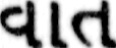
વાત
